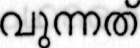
വുന്നത്
